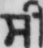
ਸੀ
